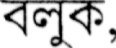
বলুক,
